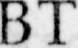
BT
